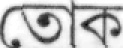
তোক
